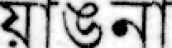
য়াঙনা
